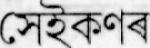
সেইকণৰ
